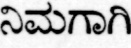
ನಿಮಗಾಗಿ
